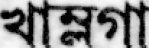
খাম্লগা
